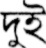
দুই
